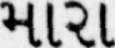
મારા
